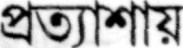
প্রত্যাশায়
